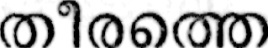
തീരത്തെ
